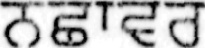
ਨਛਾਵਰ
